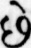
છે
